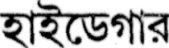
হাইডেগার
